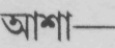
আশা-
